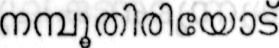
നമ്പൂതിരിയോട്
